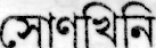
সোণখিনি
